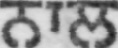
ਨਾਲ
